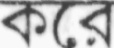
করে
